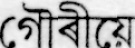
গৌৰীয়ে
